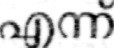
എന്ന്
